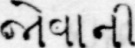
જોવાની
